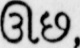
ઊછ,
